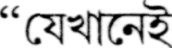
“যেখানেই
